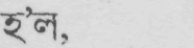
হ'ল,
